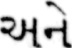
અને
